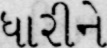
ધારીને
